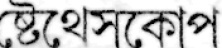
ষ্টেথেসকোপ
